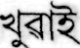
খুৱাই
